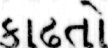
કાઢતો
